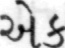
એક
